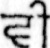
ਵੀ
